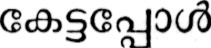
കേട്ടപ്പോള്‍
